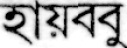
হায়ববু
